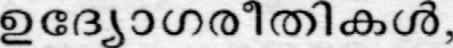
ഉദ്യോഗരീതികള്‍,
